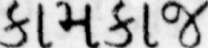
કામકાજ
